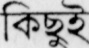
কিছুই
